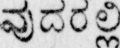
ವುದರಲ್ಲಿ
